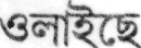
ওলাইছে
